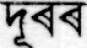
দূৰৰ
